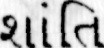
શાંતિ
